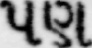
પણ
